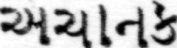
અચાનક
